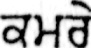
ਕਮਰੇ
